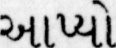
આપ્યો
